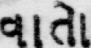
વાતો
